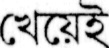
খেয়েই
